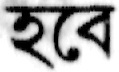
হবে
